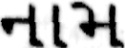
નામ
